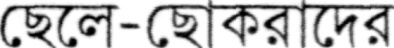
ছেলে-ছোকরাদের
